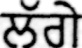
ਲੱਗੇ
